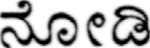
ನೋಡಿ
